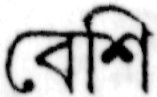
বেশি
